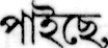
পাইছে,
